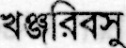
খঞ্জরিবসু
